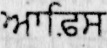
ਆਫ਼ਿਸ
